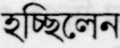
হচ্ছিলেন
